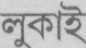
লুকাই
